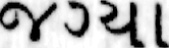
જગ્યા
